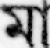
মা
